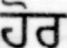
ਹੋਰ
